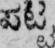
ಪಟ್ಟ
